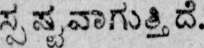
ಸ್ಪಷ್ಟವಾಗುತ್ತಿದೆ.
